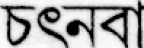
চৎনবা
